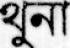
থুনা
